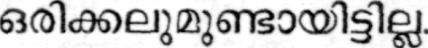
ഒരിക്കലുമുണ്ടായിട്ടില്ല.
